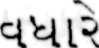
વઘારે
